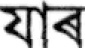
যাৰ
